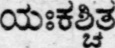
ಯಃಕಶ್ಚಿತ
